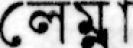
লেম্না
